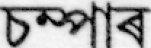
চম্পাৰ
